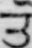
ਤੋ
